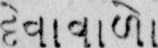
દેવાવાળો
